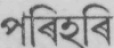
পৰিহৰি
